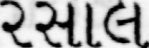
રસાલ
